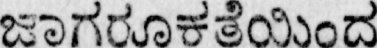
ಜಾಗರೂಕತೆಯಿಂದ
